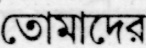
তোমাদের
